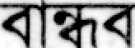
বান্ধব
